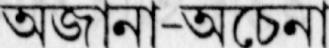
অজানা-অচেনা
